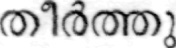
തീര്‍ത്തു
